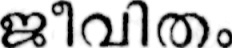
ജീവിതം
